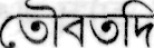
তৌবতদি
